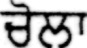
ਚੋਲਾ
